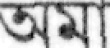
অমা
